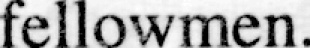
fellowmen.
